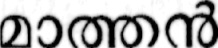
മാത്തന്‍
